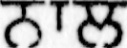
ਨਾਲ
